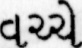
વચ્ચે
